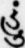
હું
